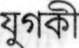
যুগকী
